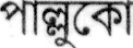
পাল্লুকো
